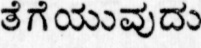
ತೆಗೆಯುವುದು
